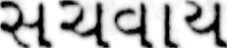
સચવાય
